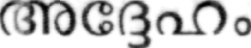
അദ്ദേഹം
